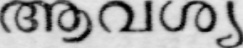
ആവശ്യ
